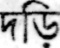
দড়ি
